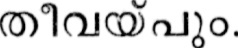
തീവയ്പും.
